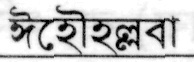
ঈহৌহল্লবা
